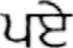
ਪਏ
